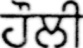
ਹੌਲੀ
